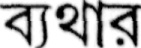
ব্যথার
